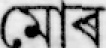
মোৰ
